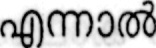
എന്നാല്‍
